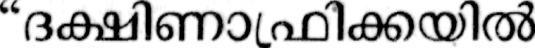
“ദക്ഷിണാഫ്രിക്കയില്‍
